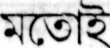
মতোই
